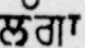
ਲੱਗਾ
